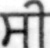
ਸੀ
